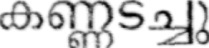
കണ്ണടച്ചു
